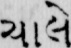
ચાલે
